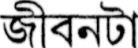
জীবনটা
